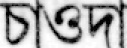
চাওদা
